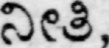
ನೀತಿ,
